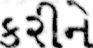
કરીને
